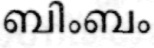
ബിംബം
